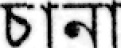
চানা
